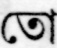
তো
